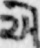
એ
